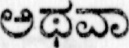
ಅಥವಾ
